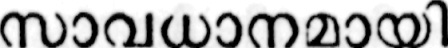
സാവധാനമായി
